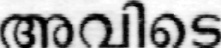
അവിടെ
